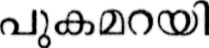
പുകമറയി
